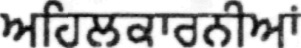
ਅਹਿਲਕਾਰਨੀਆਂ
